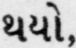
થયો,
